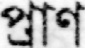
প্রাণ
